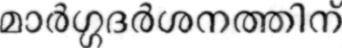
മാര്‍ഗ്ഗദര്‍ശനത്തിന്
